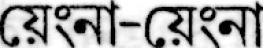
য়েংনা-য়েংনা
